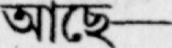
আছে-
